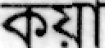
কয়া
